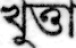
খুত্তা
